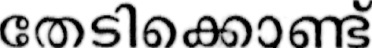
തേടിക്കൊണ്ട്
